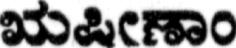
ಋಷೀಣಾ೦
